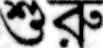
শুরু
